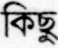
কিছু
